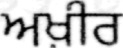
ਅਖ਼ੀਰ
